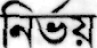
নির্ভয়
